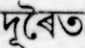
দূৰৈত
